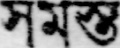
সমস্ত
